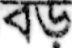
বড়
